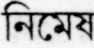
নিমেষ
